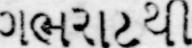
ગભરાટથી
